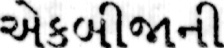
એકબીજાની
